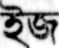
ইজ
